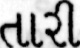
તારી
